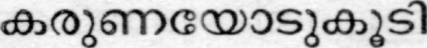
കരുണയോടുകൂടി
